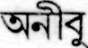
অনীবু
